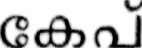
കേപ്
